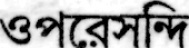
ওপরেসন্দি
